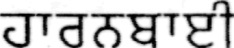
ਹਾਰਨਬਾਈ
